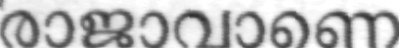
രാജാവാണെ
